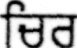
ਚਿਰ
